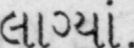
લાગ્યાં.
